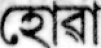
হোৱা
